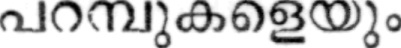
പറമ്പുകളെയും
